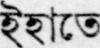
ইহাতে
